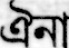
ঐনা
